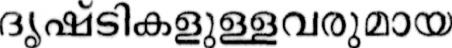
ദൃഷ്ടികളുള്ളവരുമായ
